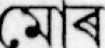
মোৰ
